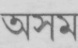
অসম
